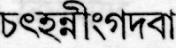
চৎহন্নীংগদবা
